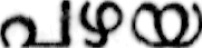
പഴയ
